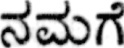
ನಮಗೆ
